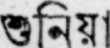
শুনিয়া
